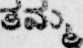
ತಮ್ಮ
